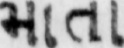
માતા
